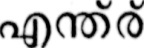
എന്ത്ര്
